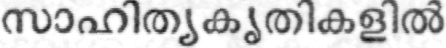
സാഹിത്യകൃതികളില്‍
